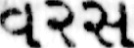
વરસ
